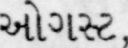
ઓગસ્ટ,
